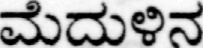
ಮೆದುಳಿನ
